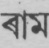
ৰাম
